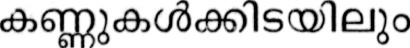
കണ്ണുകള്‍ക്കിടയിലും
